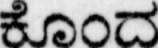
ಕೊಂದ
